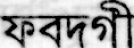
ফবদগী
